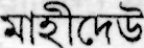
মাহীদেউ
